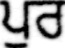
ਪੁਰ
